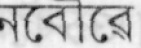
নবৌৱে
